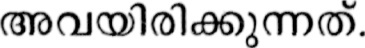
അവയിരിക്കുന്നത്.
